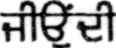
ਜੀਉਂਦੀ
